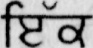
ਇੱਕ
